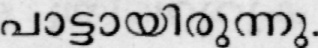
പാട്ടായിരുന്നു.
